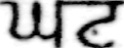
ਘਟ
